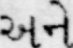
અને
